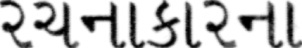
રચનાકારના
